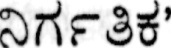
ನಿರ್ಗತಿಕ'
